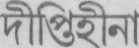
দীপ্তিহীনা
